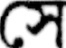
সে
